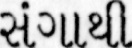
સંગાથી
